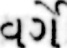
વર્ગે
